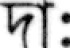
দা:
